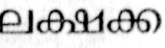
ലക്ഷക്ക
